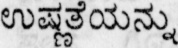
ಉಷ್ಣತೆಯನ್ನು
